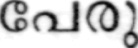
പേരു
